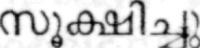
സൂക്ഷിച്ചു
